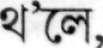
থ'লে,
